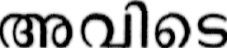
അവിടെ
